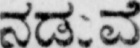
ನಡುವೆ
